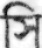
সি
